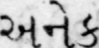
અનેક
